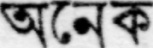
অনেক
